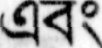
এবং
